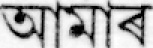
আমাৰ
